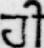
ਹੀ
